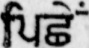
ਪਿਛੇਂ
